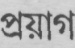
প্ৰয়াগ
